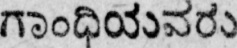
ಗಾಂಧಿಯವರು
